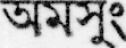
অমসুং
